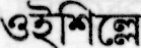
ওইশিল্লে
